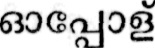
ഓപ്പോള്
